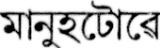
মানুহটোৱে
